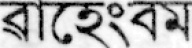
ৱাহেংবম
